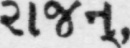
રાજન્,
